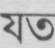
যত
